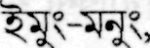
ইমুং-মনুং,
